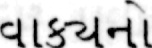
વાક્યનો
